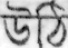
উঠি
